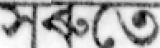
সৰুতে
